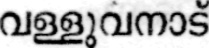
വള്ളുവനാട്
